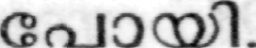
പോയി.
